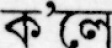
ক'লে
